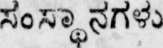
ಸಂಸ್ಥಾನಗಳು
